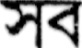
সব
